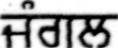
ਜੰਗਲ
